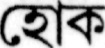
হোক
